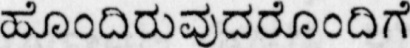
ಹೊಂದಿರುವುದರೊಂದಿಗೆ
